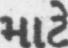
માટે
